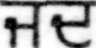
ਜਦ
